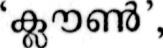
'ക്ലൌണ്‍',
